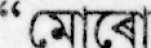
"মোৰো
